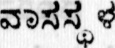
ವಾಸಸ್ಥಳ
